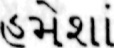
હમેશાં
